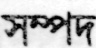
সম্পদ
